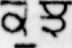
ਕੁਝ
